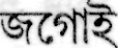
জগোই
